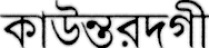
কাউন্তরদগী
